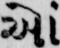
ઓં
